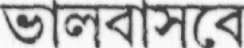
ভালবাসবে
